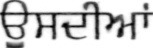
ਉਸਦੀਆਂ
